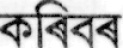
কৰিবৰ
